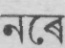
নৰে
